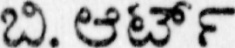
ಬಿ.ಆರ್ಟ್
